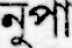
নুপা
